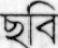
ছবি
